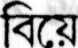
বিয়ে
